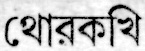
থোরকখি
